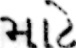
માટે
